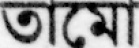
তামো
